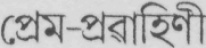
প্ৰেম-প্ৰৱাহিণী
